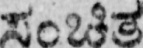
ಸಂಚಿತ
